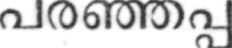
പരഞ്ഞപ്പ
